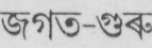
জগত-গুৰু
